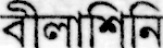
বীলাশিনি
